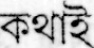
কথাই
